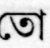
তো
